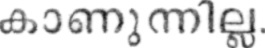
കാണുന്നില്ല.
